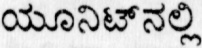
ಯೂನಿಟ್‌ನಲ್ಲಿ
